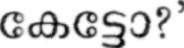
കേട്ടോ?’
